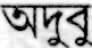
অদুবু
